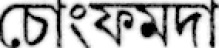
চোংফমদা
